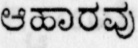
ಆಹಾರವು
